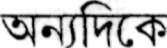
অন্যদিকে
